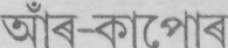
আঁৰ-কাপোৰ
